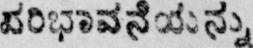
ಪರಿಭಾವನೆಯನ್ನು
